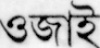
ওজাই
